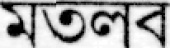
মতলব
